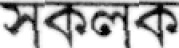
সকলক
